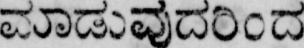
ಮಾಡುವುದರಿಂದ
